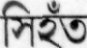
সিহঁত
